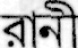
রানী
